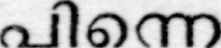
പിന്നെ
